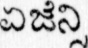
ಏಜೆನ್ಸಿ
